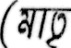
(মাতৃ
